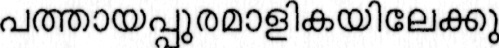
പത്തായപ്പുരമാളികയിലേക്കു
